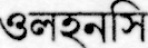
ওলহনসি
